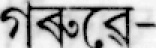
গৰুৱে-
